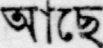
আছে
